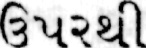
ઉપરથી
